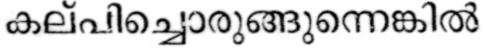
കല്പിച്ചൊരുങ്ങുന്നെങ്കില്‍
